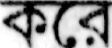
করে
